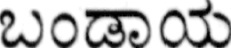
ಬಂಡಾಯ
